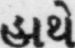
હાથે
